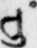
તું
